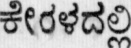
ಕೇರಳದಲ್ಲಿ
